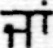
ਜਾਂ
